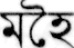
মহৈ
